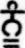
ਨੂੰ
